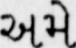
અમે
